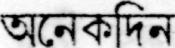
অনেকদিন
